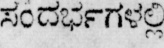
ಸಂದರ್ಭಗಳಲ್ಲಿ
